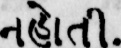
નહોતી.
